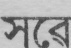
সৱে
